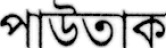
পাউতাক
